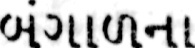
બંગાળના
